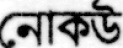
নোকউ
